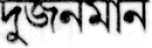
দুজনমান
